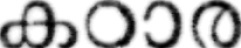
കഠാര
